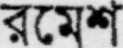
রমেশ
